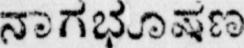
ನಾಗಭೂಷಣ
